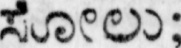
ಸೋಲು;
